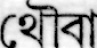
থৌবা
